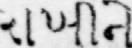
રાખીને
